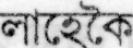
লাহেকৈ
